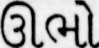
ઊભો
